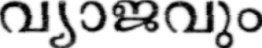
വ്യാജവും
